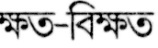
ক্ষত-বিক্ষত
